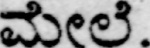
ಮೇಲೆ.
